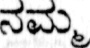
ನಮ್ಮ
